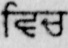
ਵਿਚ
